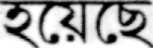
হয়েছে
